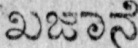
ಖಜಾನೆ
